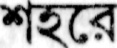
শহরে
